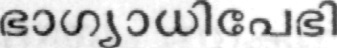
ഭാഗ്യാധിപേഭി
